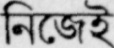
নিজেই
